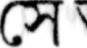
সে
